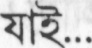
যাই...
